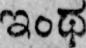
ಇಂಥ
